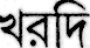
খরদি
